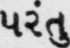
પરંતુ
